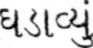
ધડાવ્યું
